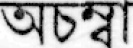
অচম্বা
